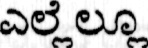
ಎಲ್ಲೆಲ್ಲೂ
